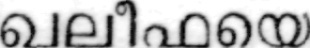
ഖലീഫയെ
